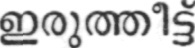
ഇരുത്തീട്ട്
